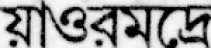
য়াওরমদ্রে
